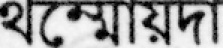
থম্মোয়দা
